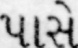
પાસે
